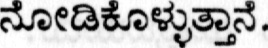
ನೋಡಿಕೊಳ್ಳುತ್ತಾನೆ.
